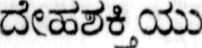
ದೇಹಶಕ್ತಿಯು
